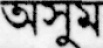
অসুম
